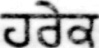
ਹਰੇਕ
